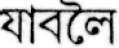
যাবলৈ
